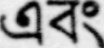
এবং
